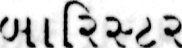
બારિસ્ટર
